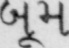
બૂમ
